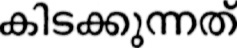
കിടക്കുന്നത്
